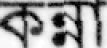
কন্না
